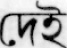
দেই
